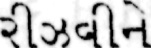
રીઝવીને
